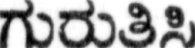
ಗುರುತಿಸಿ
